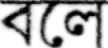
বলে
